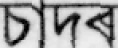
চাদৰ
